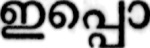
ഇപ്പൊ
